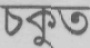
চকুত
